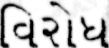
વિરોધ
